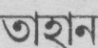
তাহান
